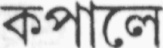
কপালে
